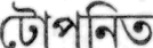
টোপনিত
